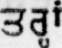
ਤਰ੍ਹਾਂ
